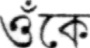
ওঁকে
